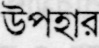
উপহার
